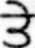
ਤੇ
